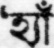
‘হ্যাঁ
